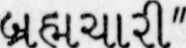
બ્રહ્મચારી"
